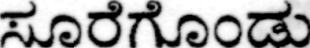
ಸೂರೆಗೊಂಡು
